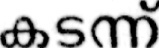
കടന്ന്
